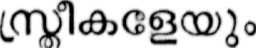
സ്ത്രീകളേയും
